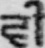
ਵੀ
